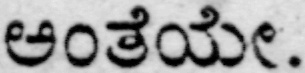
ಅಂತೆಯೇ.
